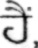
ਹੈਂ,
